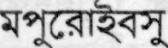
মপুরোইবসু
